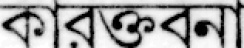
কারক্তবনা
